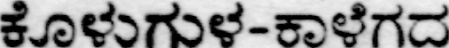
ಕೊಳಗುಳ-ಕಾಳೆಗದ
